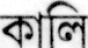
কালি
